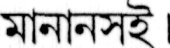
মানানসই।
